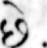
છે.
